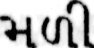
મળી
